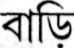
বাড়ি
